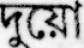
দুয়ো
